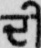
ਦੀ
